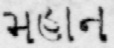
મહાન
